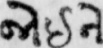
જોઈને
